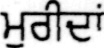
ਮੁਰੀਦਾਂ
